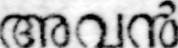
അവന്‍
